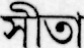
সীতা
